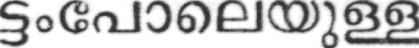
ട്ടംപോലെയുള്ള
